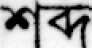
শব্দ
